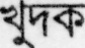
খুদক
